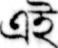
এই
